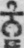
ਨੂੰ
